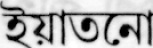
ইয়াতনো
